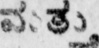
ಮತ್ತು
